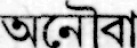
অনৌবা
